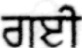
ਗਈ
